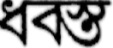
ধবস্ত
